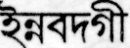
ইন্নবদগী
